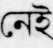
নেই
